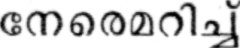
നേരെമറിച്ച്
